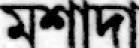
মশাদা
